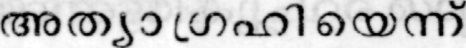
അത്യാഗ്രഹിയെന്ന്
